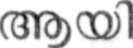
ആയി
